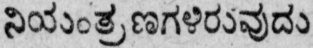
ನಿಯಂತ್ರಣಗಳಿರುವುದು
